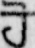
ਹੋ
